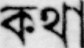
কথা
